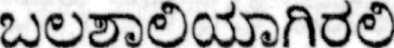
ಬಲಶಾಲಿಯಾಗಿರಲಿ
